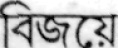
বিজয়ে
